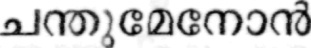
ചന്തുമേനോന്‍
